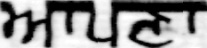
ਆਪਣਾ
